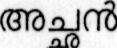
അച്ഛന്‍
